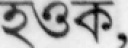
হওক,
